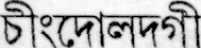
চীংদোলদগী
